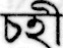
চহী
